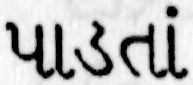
પાડતાં
